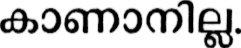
കാണാനില്ല.
